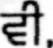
ਵੀ,
